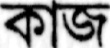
কাজ
